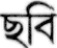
ছবি
